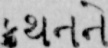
કથનને
